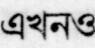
এখনও
